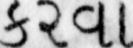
કરવા
